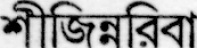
শীজিন্নরিবা
